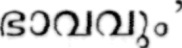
ഭാവവും'
